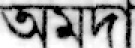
অমদা
